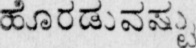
ಹೊರಡುವಷ್ಟು
